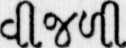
વીજળી
